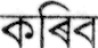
কৰিব
